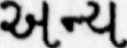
અન્ય
